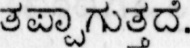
ತಪ್ಪಾಗುತ್ತದೆ.
